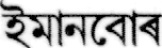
ইমানবোৰ
